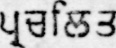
ਪ੍ਰਚਲਿਤ
